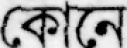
কোনে
